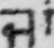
ਜਾਂ
